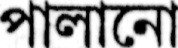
পালানো
